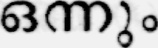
ഒന്നും
